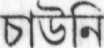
চাউনি
